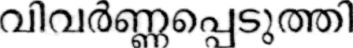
വിവര്‍ണ്ണപ്പെടുത്തി
